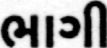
ભાગી
